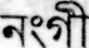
নংগী
